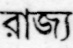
রাজ্য
